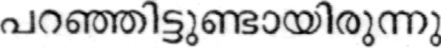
പറഞ്ഞിട്ടുണ്ടായിരുന്നു.
